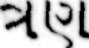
ત્રણ
